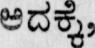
ಅದಕ್ಕೆ,
